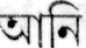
আনি
